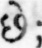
છે;
